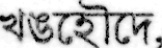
খঙহৌদে,
